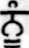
ਨੂੰ
